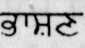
ਭਾਸ਼ਣ
